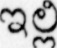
ಇಲ್ಲಿ
